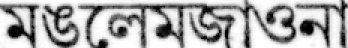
মঙলেমজাওনা
